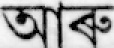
আৰু
